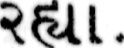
રહ્યા.
